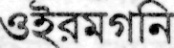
ওইরমগনি
